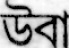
উবা
